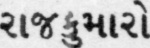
રાજકુમારો
